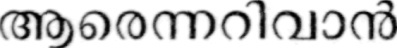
ആരെന്നറിവാന്‍
